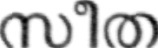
സീത
